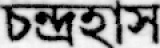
চন্দ্রহাস
